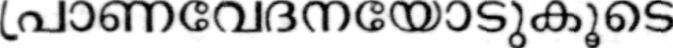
പ്രാണവേദനയോടുകൂടെ
